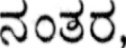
ನಂತರ,
